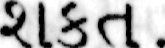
શકત.
